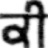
ਕੀ
